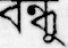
বন্ধু
